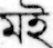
মই
